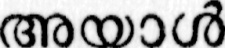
അയാള്‍
